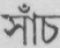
সাঁচ
